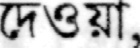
দেওয়া,
